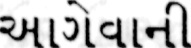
આગેવાની
